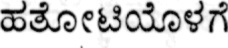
ಹತೋಟಿಯೊಳಗೆ
